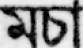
মচা
